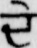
ਦੇ
